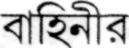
বাহিনীর
